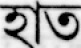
হাত
